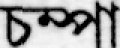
চম্পা
